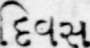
દિવસ
